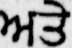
ਅਤੇ
